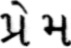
પ્રેમ
